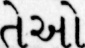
તેઓ
